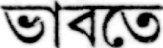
ভাবতে
